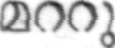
മററു
